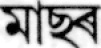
মাছৰ
